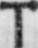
T
